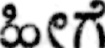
ಹೀಗೆ
